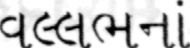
વલ્લભનાં
